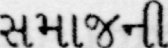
સમાજની
